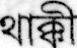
থাক্কী
